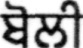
ਬੋਲੀ
